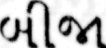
બીજા
